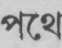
পথে
